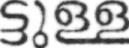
ട്ടുള്ള
